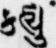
કહ્યું
